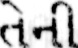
તેની
